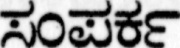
ಸಂಪರ್ಕ
